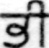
ਭੀ
